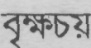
বৃক্ষচয়
